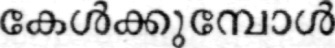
കേള്‍ക്കുമ്പോള്‍
